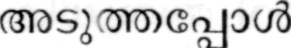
അടുത്തപ്പോള്‍
